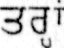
ਤਰ੍ਹਾਂ
